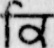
ਕਿ
